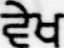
ਵੇਖ
